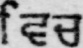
ਵਿਚ
